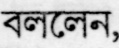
বললেন,
